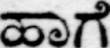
ಹಾಗೆ
